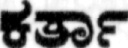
ಕರ್ತಾ
